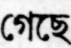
গেছে
